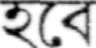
হবে
